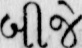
બીજે
